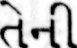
તેની
